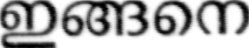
ഇങ്ങനെ
